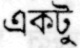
একটু
